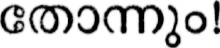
തോന്നും!
